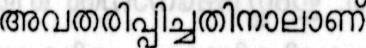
അവതരിപ്പിച്ചതിനാലാണ്
